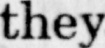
they
